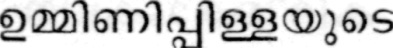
ഉമ്മിണിപ്പിള്ളയുടെ
